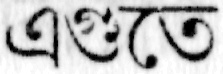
এগুতে
